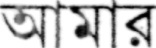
আমার
